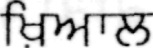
ਖ਼ਿਆਲ
